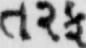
તરફ
